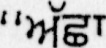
''ਅੱਛਾ
